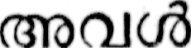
അവള്‍
